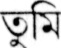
তুমি
